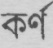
কৰ্ণ
